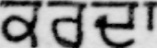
ਕਰਦਾ
